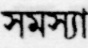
সমস্যা
